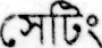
সেটিং
